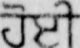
ਹੋਈ
